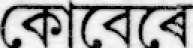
কোবেৰে
